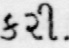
કરી.
